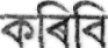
কৰিবি
